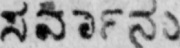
ಸರ್ವಾನು
